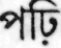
পঢ়ি
